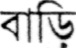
বাড়ি
